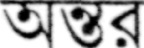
অন্তর
